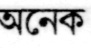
অনেক
